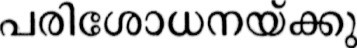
പരിശോധനയ്ക്കു
